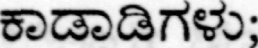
ಕಾಡಾಡಿಗಳು;
